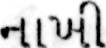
નાખી
